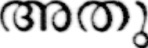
അതു
